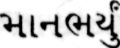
માનભર્યું
